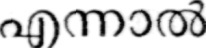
എന്നാല്‍
